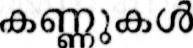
കണ്ണുകള്‍
